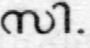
സി.
